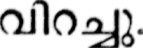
വിറച്ചു.
